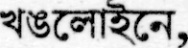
খঙলোইনে,
